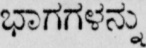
ಭಾಗಗಳನ್ನು
